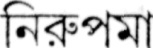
নিরুপমা
